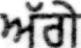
ਅੱਗੇ
